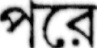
পরে
